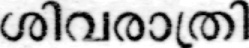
ശിവരാത്രി
